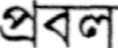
প্রবল
